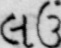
લઉં
